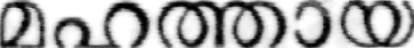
മഹത്തായ
